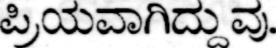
ಪ್ರಿಯವಾಗಿದ್ದುವು.
